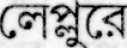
লেপ্লুরে
